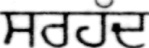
ਸਰਹੱਦ
